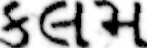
કલમ
